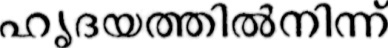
ഹൃദയത്തില്‍നിന്ന്
